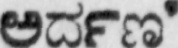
ಅರ್ದಣ
